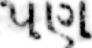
પણ
